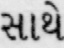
સાથે
